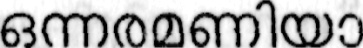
ഒന്നരമണിയാ
